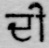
ਦੀ
